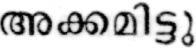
അക്കമിട്ടു
